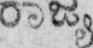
ರಾಜ್ಯ
